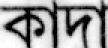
কাদা
